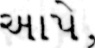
આપે,
